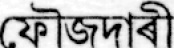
ফৌজদাৰী
